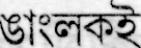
ঙাংলকই
